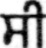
ਸੀ
